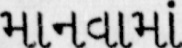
માનવામાં
